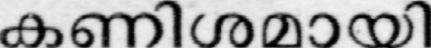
കണിശമായി
